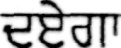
ਦਏਗਾ
